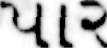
પાર
